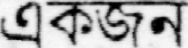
একজন
